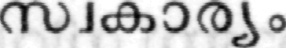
സ്വകാര്യം
